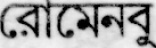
রোমেনবু
